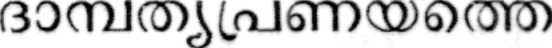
ദാമ്പത്യപ്രണയത്തെ
